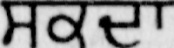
ਸਕਦਾ
